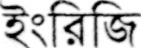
ইংরিজি
